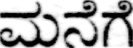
ಮನೆಗೆ
